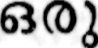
ഒരു
